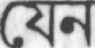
যেন
